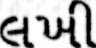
લખી
